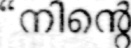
“നിന്റെ
